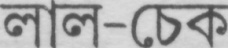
লাল-চেক
